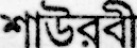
শাউরবী
